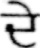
ਦੇ
